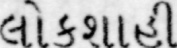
લોકશાહી
